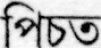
পিচত
